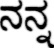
ನನ್ನ
